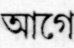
আগে
